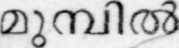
മുമ്പില്‍
